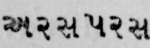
અરસપરસ
